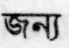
জন্য
